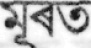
মূৰত
